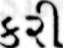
કરી
